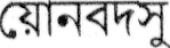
য়োনবদসু
